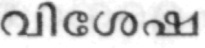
വിശേഷ
